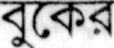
বুকের
